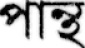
পান্থ
